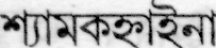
শ্যামকহ্ণাইনা
